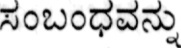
ಸಂಬಂಧವನ್ನು
